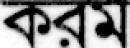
করম
